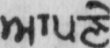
ਆਪਣੇ
